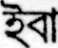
ইবা
